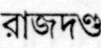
রাজদণ্ড
